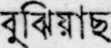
বুঝিয়াছ
